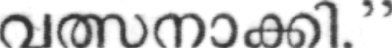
വത്സനാക്കി."
